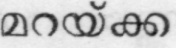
മറയ്ക്ക
